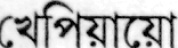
খেপিয়ায়ো
